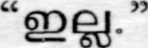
"ഇല്ല.''
